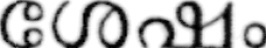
ശേഷം
